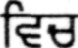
ਵਿਚ
